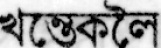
খন্তেকলৈ
